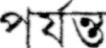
পর্যন্ত
